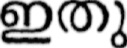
ഇതു
